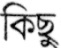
কিছু
